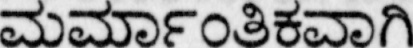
ಮರ್ಮಾಂತಿಕವಾಗಿ
